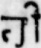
ਹੀ
